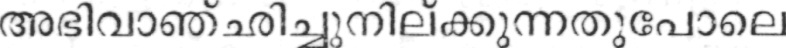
അഭിവാഞ്ഛിച്ചുനില്ക്കുന്നതുപോലെ
